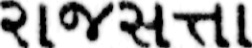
રાજસત્તા
